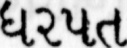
ધરપત
